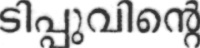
ടിപ്പുവിന്റെ
